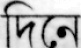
দিনে
